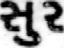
સુર
